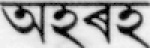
অহৰহ
